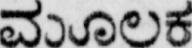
ಮೂಲಕ
